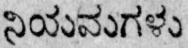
ನಿಯಮಗಳ
